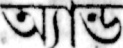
অ্যান্ড
